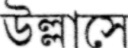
উল্লাসে
